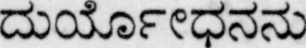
ದುರ್ಯೋಧನನು
